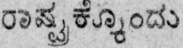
ರಾಷ್ಟ್ರಕ್ಕೊಂದು
